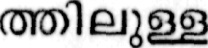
ത്തിലുള്ള
